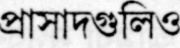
প্রাসাদগুলিও
